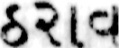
ઠરાવ
